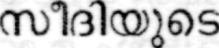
സീദിയുടെ
